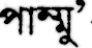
পাম্মু’
